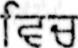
ਵਿਚ
